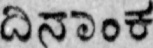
ದಿನಾಂಕ
